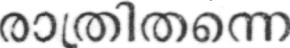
രാത്രിതന്നെ
